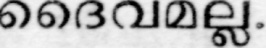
ദൈവമല്ല.
